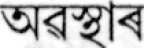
অৱস্থাৰ
